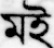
মই
